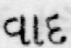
વાદ
